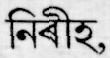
নিৰীহ,
